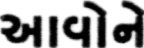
આવોને
